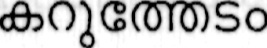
കറുത്തേടം
